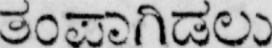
ತಂಪಾಗಿಡಲು
